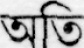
অতি
